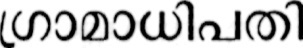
ഗ്രാമാധിപതി
